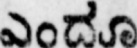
ಎಂದೂ
